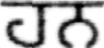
ਹਨ
